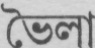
ভৈলা
